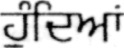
ਹੁੰਦਿਆਂ
